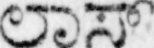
ಲಾಸ್
